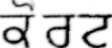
ਕੋਰਟ
